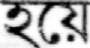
হয়ে
